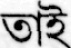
তাই
